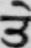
ਤੇ
